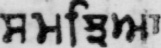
ਸਮਝਿਆ
